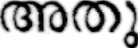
അതു
